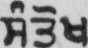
ਸੰਤੋਖ
